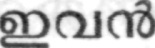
ഇവന്‍
